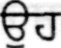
ਉਹ
